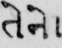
તેનો
